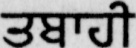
ਤਬਾਹੀ
